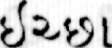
ઈચ્છા
